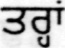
ਤਰ੍ਹਾਂ
